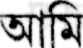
আমি
